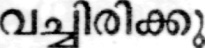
വച്ചിരിക്കു
